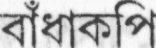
বাঁধাকপি
